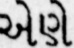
એણે
